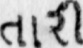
તારી
